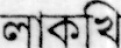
লাকখি
